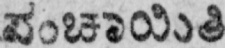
ಪಂಚಾಯಿತಿ
